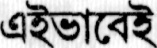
এইভাবেই
